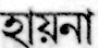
হায়না
